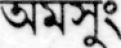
অমসুং
